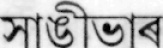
সাঙীভাৰ
